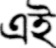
এই
